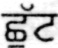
ਛੁੱਟ
